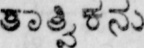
ತಾತ್ವಿಕನು
